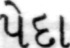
પેદા
